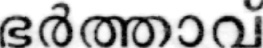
ഭര്‍ത്താവ്
